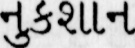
નુકશાન
